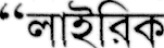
“লাইরিক
